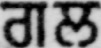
ਗਲ
